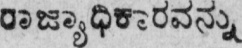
ರಾಜ್ಯಾಧಿಕಾರವನ್ನು
